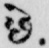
છે.
